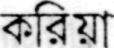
করিয়া
